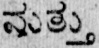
ಮತ್ತು
